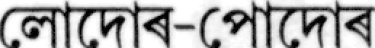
লোদোৰ-পোদোৰ
